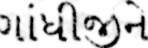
ગાંધીજીને
